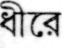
ধীরে
